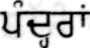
ਪੰਦ੍ਹਰਾਂ
